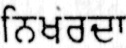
ਨਿਖਰਦਾ
